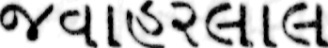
જવાહરલાલ
